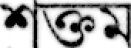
শক্তম
